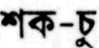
শক-চু
